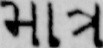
માત્ર
